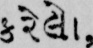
કરેલો,
